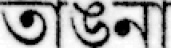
তাঙনা
